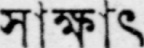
সাক্ষাৎ
